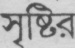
সৃষ্টির
